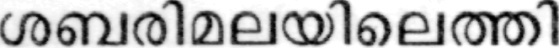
ശബരിമലയിലെത്തി
